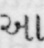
આ
